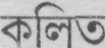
কলিত
